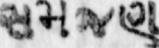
સમજણ
